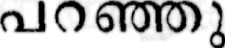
പറഞ്ഞു
